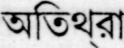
অতিথ্রা
